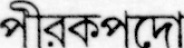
পীরকপদো
